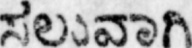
ಸಲುವಾಗಿ
